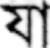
যা
